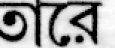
তারে
